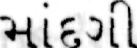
માંદગી
